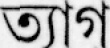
ত্যাগ
